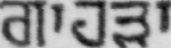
ਗਾਹੜਾ
